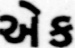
એક
